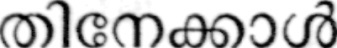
തിനേക്കാള്‍
